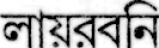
লায়রবনি
